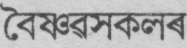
বৈষ্ণৱসকলৰ
